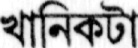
খানিকটা
